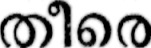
തീരെ
